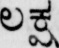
ಲಕ್ಷ
